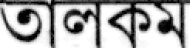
তালকম
